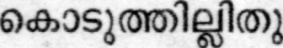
കൊടുത്തില്ലിതു
